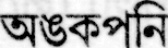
অঙকপনি
